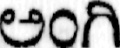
ಅಂಗಿ
